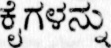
ಕೈಗಳನ್ನು
